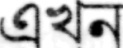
এখন
